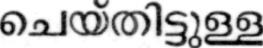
ചെയ്തിട്ടുള്ള
